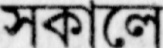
সকালে
